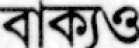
বাক্যও
